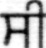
ਸੀ
